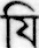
যি
